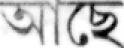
আছে
